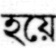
হয়ে
